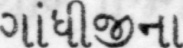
ગાંધીજીનાં
